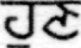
ਹੁਣ
